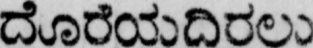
ದೊರೆಯದಿರಲು
